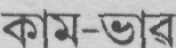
কাম-ভাৱ
